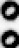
ঃ
